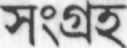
সংগ্রহ
